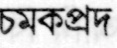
চমকপ্রদ
